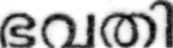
ഭവതി
